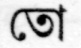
তো
